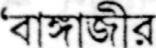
‘বাঙ্গাজীর
